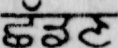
ਛੱਡਣ
